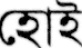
হোই
